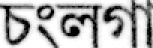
চংলগা
